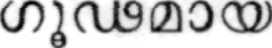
ഗൂഢമായ
